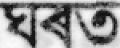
ঘৰত
